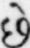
છે
